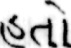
હતો
